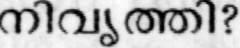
നിവൃത്തി?
